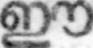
ഈ
